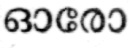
ഓരോ
